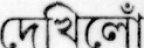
দেখিলোঁ
